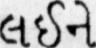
લઈને
